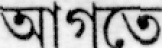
আগতে
